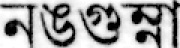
নঙগুম্না
